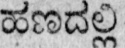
ಹಣದಲ್ಲಿ
